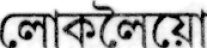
লোকলৈয়ো
